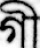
গী
